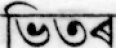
ভিতৰ
